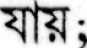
যায়;
